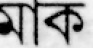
মাক
